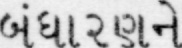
બંધારણને
